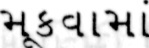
મૂકવામાં
